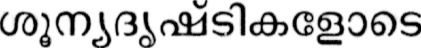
ശൂന്യദൃഷ്ടികളോടെ
